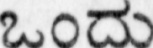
ಒಂದು
